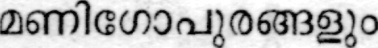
മണിഗോപുരങ്ങളും
